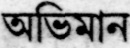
অভিমান
